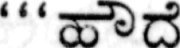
"'ಹೌದೆ
